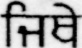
ਜਿਥੇ
